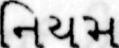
નિયમ
